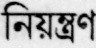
নিয়ন্ত্রণ
